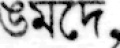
ঙমদে,
